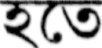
হতে
